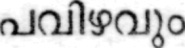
പവിഴവും
